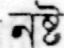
নষ্ট
